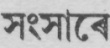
সংসাৰে
